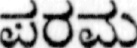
ಪರಮ
